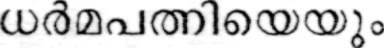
ധര്‍മപത്നിയെയും
